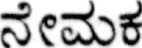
ನೇಮಕ
